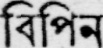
বিপিন
